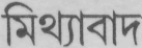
মিথ্যাবাদ
